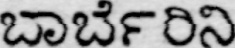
ಬಾರ್ಬೆರಿನಿ
